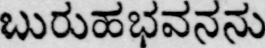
ಬುರುಹಭವನನು
